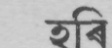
হৰি
